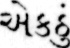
એકઠું
